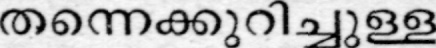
തന്നെക്കുറിച്ചുള്ള
